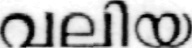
വലിയ
